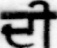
ਦੀ
